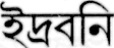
ইদ্রবনি
